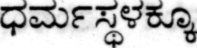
ಧರ್ಮಸ್ಥಳಕ್ಕೂ
